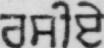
ਰਸੀਏ
